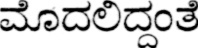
ಮೊದಲಿದ್ದಂತೆ
